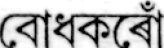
বোধকৰোঁ
